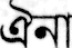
ঐনা
